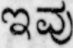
ಇವು
